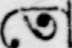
তো
